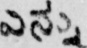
ಎನ್ನು
